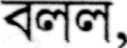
বলল,
